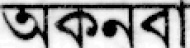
অকনবা
